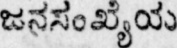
ಜನಸಂಖ್ಯೆಯ
